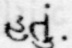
હતું.
